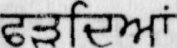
ਫੜਦਿਆਂ
